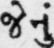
જેનું
